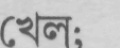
খেল;
